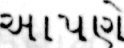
આપણે
